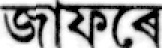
জাফৰে
